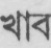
খাব
